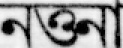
নত্তনা
